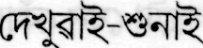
দেখুৱাই-শুনাই
